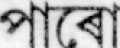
পাৰো
